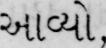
આવ્યો,
